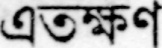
এতক্ষণ
